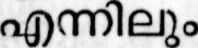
എന്നിലും
